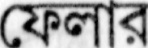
ফেলার
